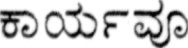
ಕಾರ್ಯವೂ
